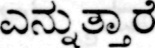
ಎನ್ನುತ್ತಾರೆ
